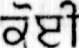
ਕੋਈ
